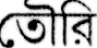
তৌরি
